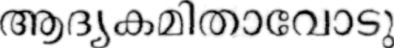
ആദ്യകമിതാവോടു
